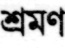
শ্রমণ
